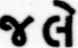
જલે
